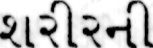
શરીરની
